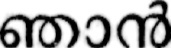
ഞാന്‍
